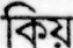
কিয়
